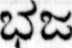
ಭಜ
